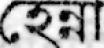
হেন্না
